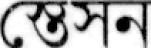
স্তেসন
